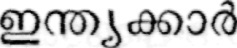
ഇന്ത്യക്കാര്‍
